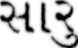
સારુ
